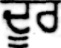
ਦੂਰ
